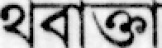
থবাক্তা
